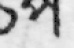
চপ
